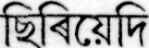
ছিৰিয়েদি
